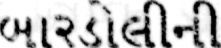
બારડોલીની
